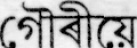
গৌৰীয়ে
